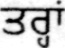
ਤਰ੍ਹਾਂ
